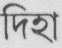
দিহা
